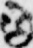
છે
